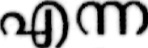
എന്ന
